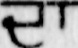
ਦਾ
